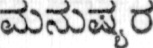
ಮನುಷ್ಯರ
